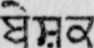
ਬੇਸ਼ਕ
